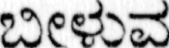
ಬೀಳುವ
